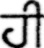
ਹੀ
